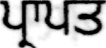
ਪ੍ਰਾਪਤ
